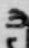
ਹੈ
